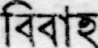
বিবাহ
